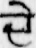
ਦੇ
